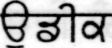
ਉਡੀਕ
